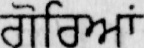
ਗੋਰਿਆਂ
